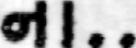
ના.....
